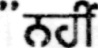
ਨਹੀਂ
